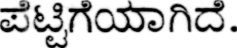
ಪೆಟ್ಟಿಗೆಯಾಗಿದೆ.
